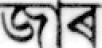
জাৰ
